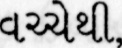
વચ્ચેથી,
